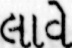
લાવે
